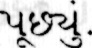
પૂછ્યું.
